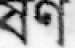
ষণ
